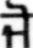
ਜੋ
